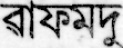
ৱাফমদু
